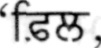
'ਫ਼ਿਲ,
